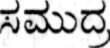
ಸಮುದ್ರ
